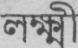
লক্ষ্মী
